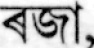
ৰজা,
